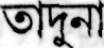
তাদুনা
